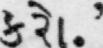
કરો.'
